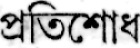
প্রতিশোধ
